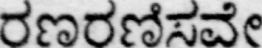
ರಣರಣಿಸವೇ
